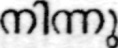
നിന്നു
